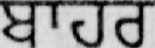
ਬਾਹਰ
